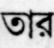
তার
